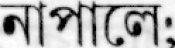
নাপালে;
